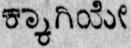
ಕ್ಕಾಗಿಯೇ
